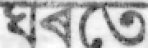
ঘৰতে
